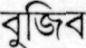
বুজিব
